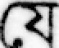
যে
